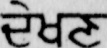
ਦੇਖਣ
